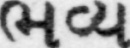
ભવ્ય
